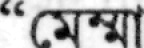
“মেম্মা
